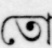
তো
